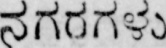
ನಗರಗಳು
